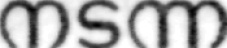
നടന്ന
